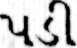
પડી
